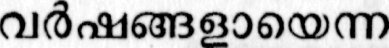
വര്‍ഷങ്ങളായെന്ന
